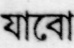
যাবো
